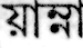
য়াম্না
